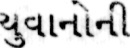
યુવાનોની
